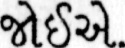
જોઈએ.
